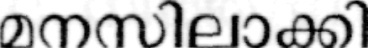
മനസിലാക്കി
